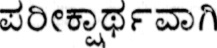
ಪರೀಕ್ಷಾರ್ಥವಾಗಿ
